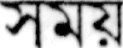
সময়
